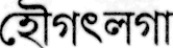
হৌগৎলগা
